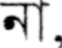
না,
